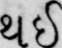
થઈ
